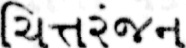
ચિત્તરંજન
